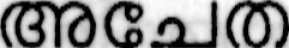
അചേത
